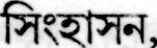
সিংহাসন,
